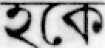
হকে
